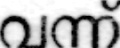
വന്ന്
